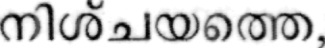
നിശ്ചയത്തെ,
